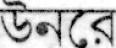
উনরে
